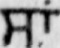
ਸਾਂ
